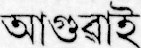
আগুৱাই
